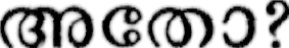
അതോ?
